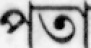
পতা
